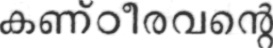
കണ്ഠീരവന്റെ
